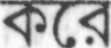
করে
